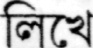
লিখে
